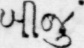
બીજું
